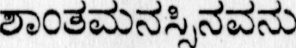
ಶಾಂತಮನಸ್ಸಿನವನು
